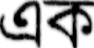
এক
